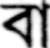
বা
